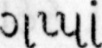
ગપ્પાં
